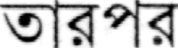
তারপর
